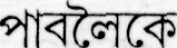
পাবলৈকে
